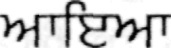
ਆਇਆ
